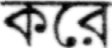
করে
